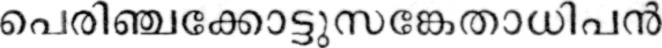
പെരിഞ്ചക്കോട്ടുസങ്കേതാധിപന്‍
